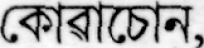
কোৱাচোন,
